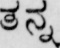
ತನ್ನ
